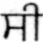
ਸੀ
